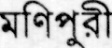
মণিপুরী
